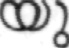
യു
